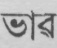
ভাৱ
